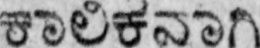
ಕಾಲಿಕವಾಗಿ
